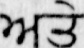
ਅਤੇ
